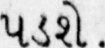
પડશે.
